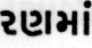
રણમાં
